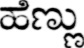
ಹೆಣ್ಣು
